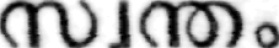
സ്വന്തം
